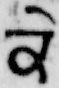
ਕੇ
